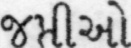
જપ્તીઓ
